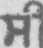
ਸੀ
